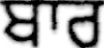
ਬਾਰ
